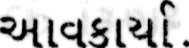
આવકાર્યા.
